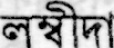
লম্বীদা
